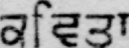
ਕਵਿਤਾ
